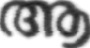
ആ
